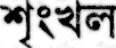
শৃংখল
